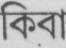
কিবা
